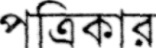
পত্রিকার
